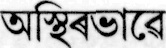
অস্থিৰভাৱে
